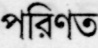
পরিণত
